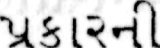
પ્રકારની
